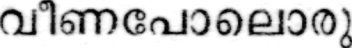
വീണപോലൊരു
